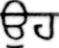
ਉਹ
